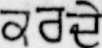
ਕਰਦੇ
